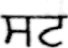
ਸਟ
